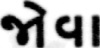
જોવા
